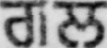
ਗਲ
